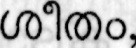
ശീതം,
